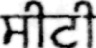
ਸੀਟੀ
